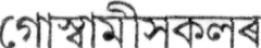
গোস্বামীসকলৰ
